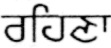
ਰਹਿਣਾ
